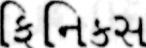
ફિનિક્સ
